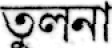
তুলনা
